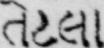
તેટલા
